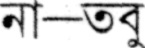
না–তবু
